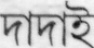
দাদাই
